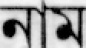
নাম
